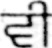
ਵੀ
